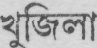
খুজিলা
